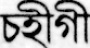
চহীগী
